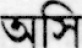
অসি
